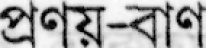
প্রণয়-বাণ
